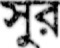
সুর
